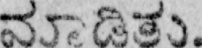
ಮಾಡಿತು.
